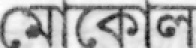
মোকোল
